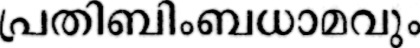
പ്രതിബിംബധാമവും
